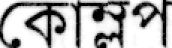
কোম্লপ
